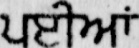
ਪਈਆਂ
